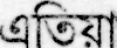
এতিয়া
